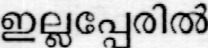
ഇല്ലപ്പേരില്‍
